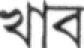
খাব
